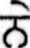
ਨੇ
